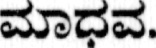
ಮಾಧವ.
